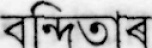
বন্দিতাৰ
